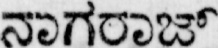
ನಾಗರಾಜ್
